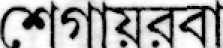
শেগায়রবা
